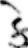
કે
